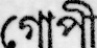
গোপী
